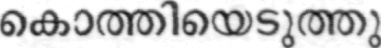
കൊത്തിയെടുത്തു
